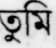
তুমি
